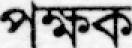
পক্ষক
